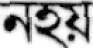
নহয়
